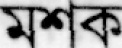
মশক
